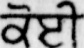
ਕੋਈ
